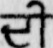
ਦੀ
